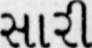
સારી
